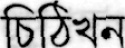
চিঠিখন
